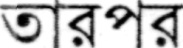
তারপর
